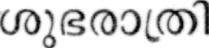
ശുഭരാത്രി
